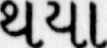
થયા
